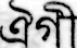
ঐগী
